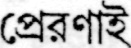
প্রেরণাই
